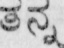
ತನ್ನ
